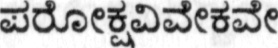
ಪರೋಕ್ಷವಿವೇಕವೇ
